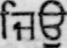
ਜਿਉ
